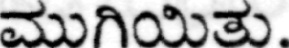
ಮುಗಿಯಿತು.
